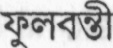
ফুলবন্তী
